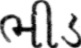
ભીડ
